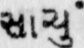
સાચું
